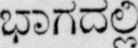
ಭಾಗದಲ್ಲಿ
